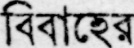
বিবাহের
